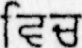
ਵਿਚ
